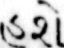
હશે
